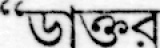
“ডাক্তর
